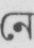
নে
